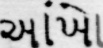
આંખો
